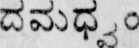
ದಮಧ್ವಂ
